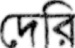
দেরি
